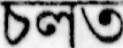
চলত
